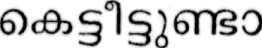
കെട്ടീട്ടുണ്ടാ
